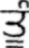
ਤੂੰ
